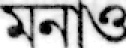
মনাও
